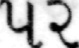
પર
